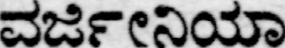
ವರ್ಜೀನಿಯಾ
